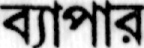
ব্যাপার
